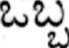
ಒಬ್ಬ
